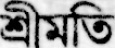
শ্রীমতি
